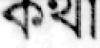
কথা
